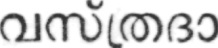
വസ്ത്രദാ
